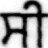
ਸੀ
